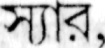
স্যার,
